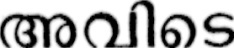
അവിടെ
